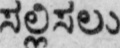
ಸಲ್ಲಿಸಲು
